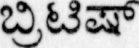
ಬ್ರಿಟಿಷ್
